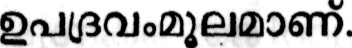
ഉപദ്രവംമൂലമാണ്.
